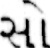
સો
